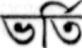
ভর্তি
